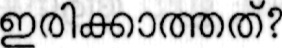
ഇരിക്കാത്തത്?
